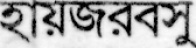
হায়জরবসু
